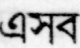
এসব
